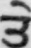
ਤੇ
